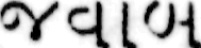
જવાબ
